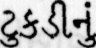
ટુકડીનું
